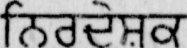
ਨਿਰਦੇਸ਼ਕ
